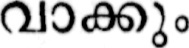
വാക്കും
